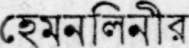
হেমনলিনীর
